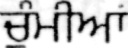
ਚੁੰਮੀਆਂ
